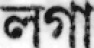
লগা
